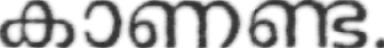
കാണണ്ട.
